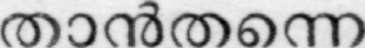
താന്‍തന്നെ
